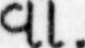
વા.
